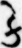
કે
